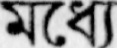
মধ্যে
